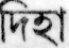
দিহা
